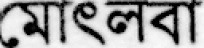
মোৎলবা
